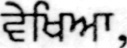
ਵੇਖਿਆ,
